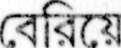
বেরিয়ে
